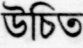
উচিত
